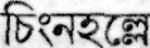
চিংনহল্লে
